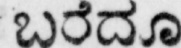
ಬರೆದೂ
